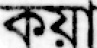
কয়া
